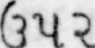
ઉપર
